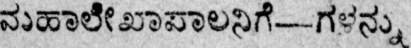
ಮಹಾಲೇಖಾಪಾಲನಿಗೆ-ಗಳನ್ನು
